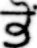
ਭੋਂ
